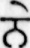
ਨੇ
